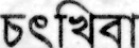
চৎখিবা
